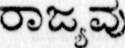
ರಾಜ್ಯವು
